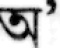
অ'
